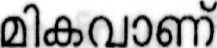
മികവാണ്
